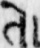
તો
